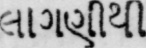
લાગણીથી
